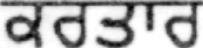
ਕਰਤਾਰ
